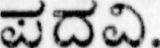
ಪದವಿ.
